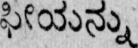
ಫೀಯನ್ನು
